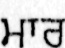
ਮਾਰ
